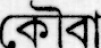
কৌবা
